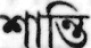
শান্তি
